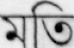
মতি
